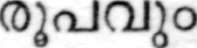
രൂപവും
